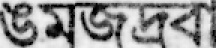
ঙমজদ্রবা
